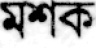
মশক
